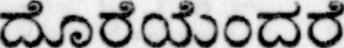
ದೊರೆಯೆಂದರೆ
